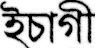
ইচাগী
